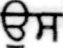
ਉਸ
